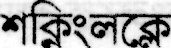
শক্নিংলক্লে
